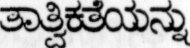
ತಾತ್ವಿಕತೆಯನ್ನು
